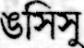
ঙসিসু
